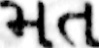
મત
